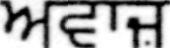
ਅਵਾਜ਼
